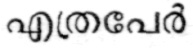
എത്രപേര്‍
